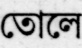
তোলে
